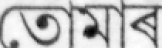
তোমাৰ
